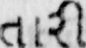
તારી
